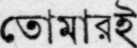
তোমারই
